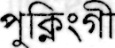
পুক্নিংগী
